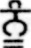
ਨੂੰ
